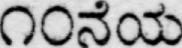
೧೦ನೆಯ
